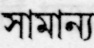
সামান্য
